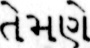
તેમણે
